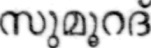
സുമൂറദ്
